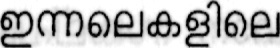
ഇന്നലെകളിലെ
